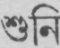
শুনি
